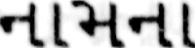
નામના
